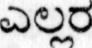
ಎಲ್ಲರ
